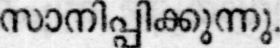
സാനിപ്പിക്കുന്നു.
